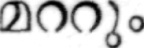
മററും
